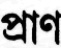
প্ৰাণ
